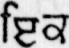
ਇਕ
